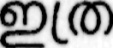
ഇത്ര
